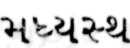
મધ્યસ્થ
